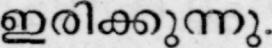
ഇരിക്കുന്നു.
